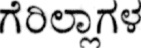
ಗೆರಿಲ್ಲಾಗಳ
